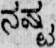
ನಷ್ಟ
